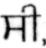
ਸੀ,
